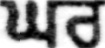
ਘਰ
